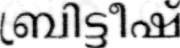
ബ്രിട്ടീഷ്
